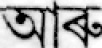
আৰু
